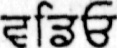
ਵਡਿਓ
